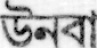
উনবা
